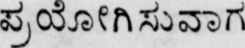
ಪ್ರಯೋಗಿಸುವಾಗ
